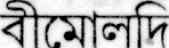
বীমোলদি
